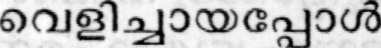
വെളിച്ചായപ്പോള്‍
